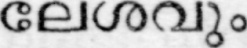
ലേശവും
